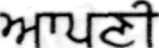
ਆਪਣੀ
